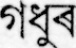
গধুৰ
